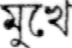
মুখে
